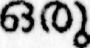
ഒരു
